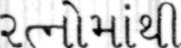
રત્નોમાંથી
